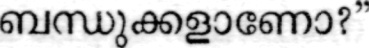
ബന്ധുക്കളാണോ?”
